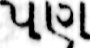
પણ
